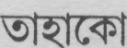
তাহাকো
